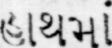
હાથમાં
